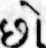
છો
